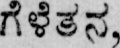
ಗೆಳೆತನ,
